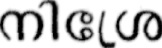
നിശ്രേ
